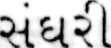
સંઘરી
